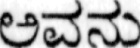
ಅವನು
